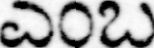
ಎಂಬ
